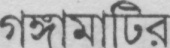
গঙ্গামাটির
